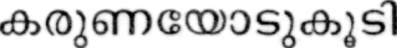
കരുണയോടുകൂടി
